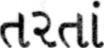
તરતાં
